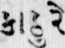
કાઠુરે
